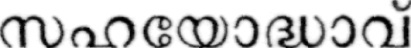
സഹയോദ്ധാവ്
